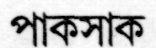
পাকসাক
